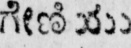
ಗೇಣಿಯು
